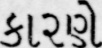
કારણે
